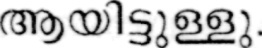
ആയിട്ടുള്ളു.
